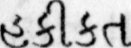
હકીકત
